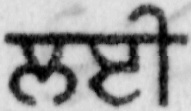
ਲਈ
